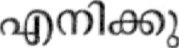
എനിക്കു
